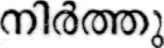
നിര്‍ത്തു
